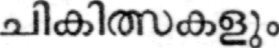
ചികിത്സകളും
